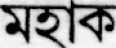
মহাক
